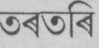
তৰতৰি
